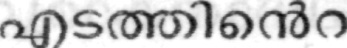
എടത്തിന്റെ
